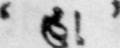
'હા'
